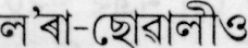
ল'ৰা-ছোৱালীও
